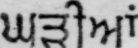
ਘੜੀਆਂ
